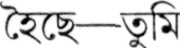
হৈছে-তুমি
